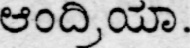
ಆಂದ್ರಿಯಾ.
